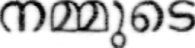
നമ്മുടെ
